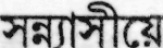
সন্ন্যাসীয়ে
